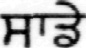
ਸਾਡੇ
